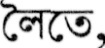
লৈতে,
